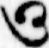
ও
